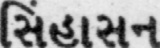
સિંહાસન
